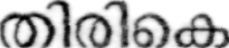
തിരികെ
